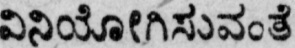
ವಿನಿಯೋಗಿಸುವಂತೆ
